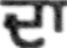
ਦਾ
